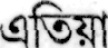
এতিয়া
